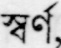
স্বর্ণ,
